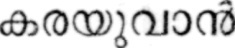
കരയുവാന്‍
